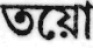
তয়ো
